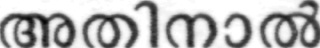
അതിനാല്‍
